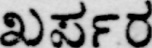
ಖರ್ಪರ
